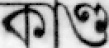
কাণ্ড
